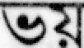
ভয়
